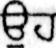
ਉਹ
